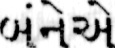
બંનેએ
